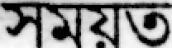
সময়ত
